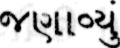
જણાવ્યું
